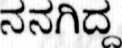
ನನಗಿದ್ದ
